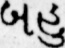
બહુ
